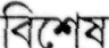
বিশেষ
